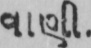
વાણી.
